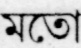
মতো
